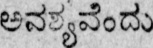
ಅವಶ್ಯವೆಂದು
